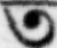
ত
